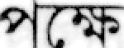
পক্ষে
